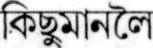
কিছুমানলৈ
